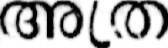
അത്ര
